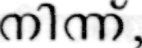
നിന്ന്,
